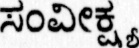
ಸಂವೀಕ್ಷ್ಯ
